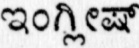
ಇಂಗ್ಲೀಷ್
